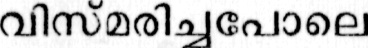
വിസ്മരിച്ചപോലെ
